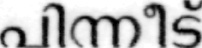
പിന്നീട്
